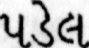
પડેલ
